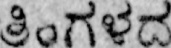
ತಿಂಗಳದ
